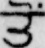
ਤੋਂ
